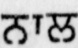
ਨਾਲ
